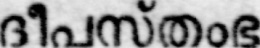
ദീപസ്തംഭ
